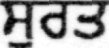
ਸੁਰਤ
